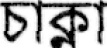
চাক্না
